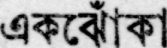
একঝোঁকা
